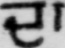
ਦਾ
